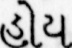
હોય
